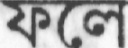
ফলে
